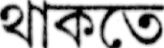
থাকতে
